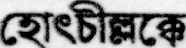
হোৎচীল্লক্কে
